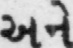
અને
